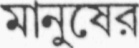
মানুষের
